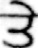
ਤੇ
